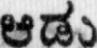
ಆಡು
